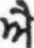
ਐ
